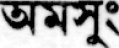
অমসুং
